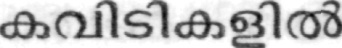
കവിടികളില്‍
